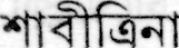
শাবীত্রিনা
